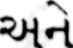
અને
